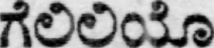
ಗೆಲಿಲಿಯೊ
